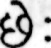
છેઃ
